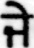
ਜੇ
